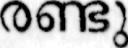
രണ്ടു
